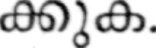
ക്കുക.
